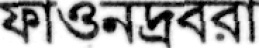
ফাওনদ্রবরা
